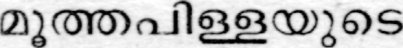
മൂത്തപിള്ളയുടെ
